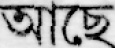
আছে
